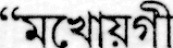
“মখোয়গী
